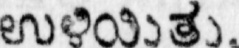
ಉಳಿಯಿತು.
